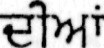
ਦੀਆਂ
